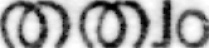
തത്വം
